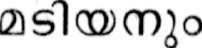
മടിയനും
